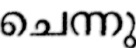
ചെന്നു
